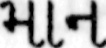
માન
